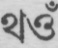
থওঁ
